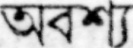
অবশ্য
